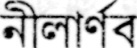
নীলার্ণব
